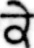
ਕੇ
